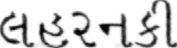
લહરનકી
